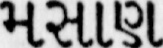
મસાણ
